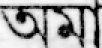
অমা
